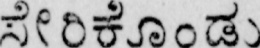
ಸೇರಿಕೊಂಡು
